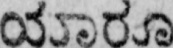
ಯಾರೂ
